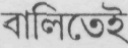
বালিতেই
